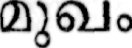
മുഖം
